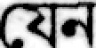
যেন
